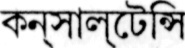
কন্সালটেন্সি
